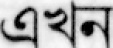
এখন
